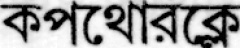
কপথোরক্লে
